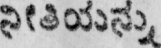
ನೀತಿಯನ್ನು
